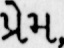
પ્રેમ,
